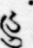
હું
